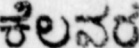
ಕೆಲವರ
